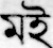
মই
